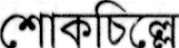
শোকচিল্লে
